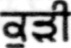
ਕੁੜੀ
